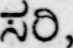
ಸರಿ,
